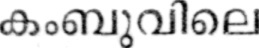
കംബുവിലെ
